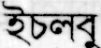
ইচলবু
